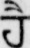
ਹੈ
